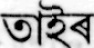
তাইৰ
